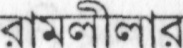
রামলীলার
